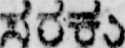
ಸರಕು
